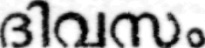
ദിവസം
